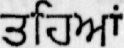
ਤਹਿਆਂ
